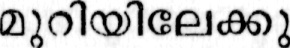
മുറിയിലേക്കു
